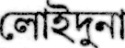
লোইদুনা
